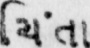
ચિંતા
